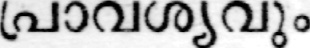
പ്രാവശ്യവും
